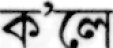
ক'লে
